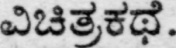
ವಿಚಿತ್ರಕಥೆ.
